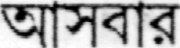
আসবার
